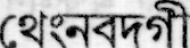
থেংনবদগী
